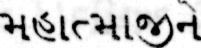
મહાત્માજીને
